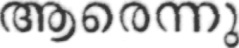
ആരെന്നു
